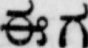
ಈಗ
